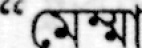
“মেম্মা
